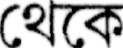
থেকে
